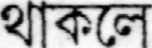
থাকলে
